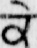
ਕੇ
